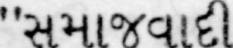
"સમાજવાદી
